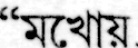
“মখোয়
